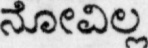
ನೋವಿಲ್ಲ
